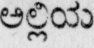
ಅಲ್ಲಿಯ
